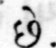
છે.
